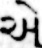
એ
